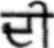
ਦੀ
